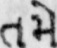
તમે
